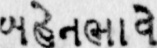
બહેનભાવે
